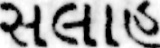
સલાહ
